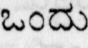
ಒಂದು
